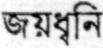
জয়ধ্বনি
